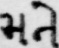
મને
